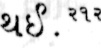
થઈ.૨૧૨
